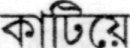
কাটিয়ে
